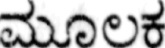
ಮೂಲಕ
